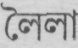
লৈলা
